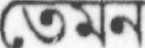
তেমন
